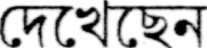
দেখেছেন
